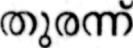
തുരന്ന്
